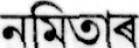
নমিতাৰ
